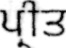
ਪ੍ਰੀਤ
